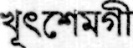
খুৎশেমগী
